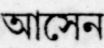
আসেন
